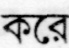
করে
